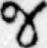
જ
